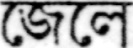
জেলে
